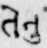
તેનું
